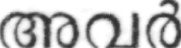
അവര്‍
